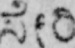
ಸೇರಿ
